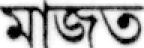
মাজত
